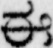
ಈ
